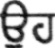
ਉਹ
